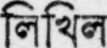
লিখিল
